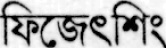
ফিজেৎশিং
